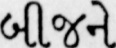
બીજને
